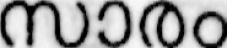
സാരം
